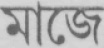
মাজে
